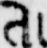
તો
